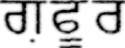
ਗ਼ਫੂਰ
